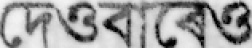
দেওবাৰেও
